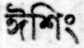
ঈশিং
